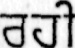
ਰਹੀ
